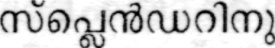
സ്പ്ലെന്‍ഡറിനു
